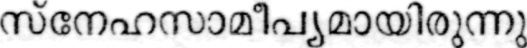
സ്നേഹസാമീപ്യമായിരുന്നു
